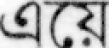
এয়ে
